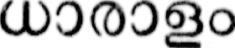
ധാരാളം
